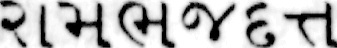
રામભજદત્ત
